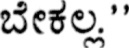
ಬೇಕಲ್ಲ."
